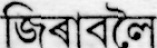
জিৰাবলৈ
